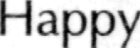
Happy
